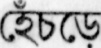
হেঁচড়ে
